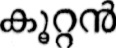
കൂറ്റന്‍
